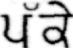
ਪੱਕੇ
